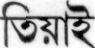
তিয়াই
